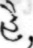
હૈ,
